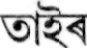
তাইৰ
